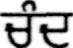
ਚੰਦ
